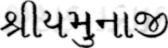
શ્રીયમુનાજી
